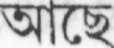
আছে
